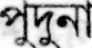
পুদুনা
